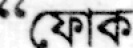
“ফোক
